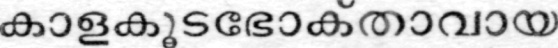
കാളകൂടഭോക്താവായ
